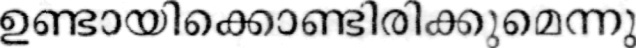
ഉണ്ടായിക്കൊണ്ടിരിക്കുമെന്നു
